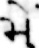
મેં
